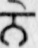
ਨੇ
